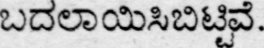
ಬದಲಾಯಿಸಿಬಿಟ್ಟಿವೆ.
